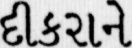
દીકરાને
